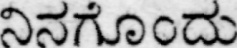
ನಿನಗೊಂದು
